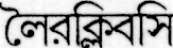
লৈরক্লিবসি
